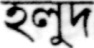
হলুদ
